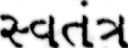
સ્વતંત્ર
